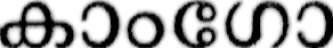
കാംഗോ
